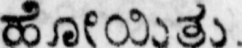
ಹೋಯಿತು.
